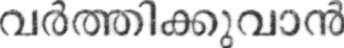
വര്‍ത്തിക്കുവാന്‍
